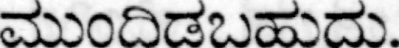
ಮುಂದಿಡಬಹುದು.
